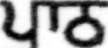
ਪਾਠ
